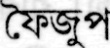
ফৈজুম
